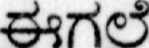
ಈಗಲೆ
